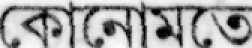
কোনোমতে
